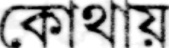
কোথায়
